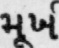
મૂર્ખ
